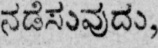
ನಡೆಸುವುದು,
